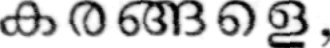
കരങ്ങളെ,
